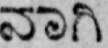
ವಾಗಿ
